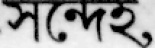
সন্দেহ,
